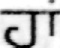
ਹਾਂ
